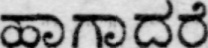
ಹಾಗಾದರೆ
